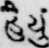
હૈયું
